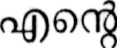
എന്റെ
